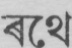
ৰথে
